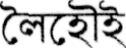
লৈহৌই
